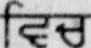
ਵਿਚ
